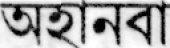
অহানবা
